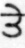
ਤੇ
